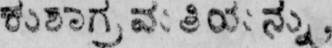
ಕುಶಾಗ್ರಮತಿಯನ್ನು,
